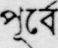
পূর্বে
